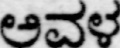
ಅವಳ
